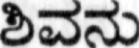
ಶಿವನು
